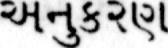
અનુકરણ
